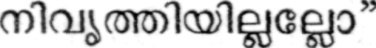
നിവൃത്തിയില്ലല്ലോ”
